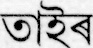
তাইৰ
